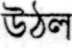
উঠল
